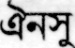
ঐনসু
